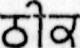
ਠੀਕ
